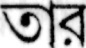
তার
